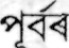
পূর্বৰ
